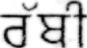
ਰੱਬੀ
